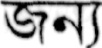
জন্য
